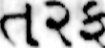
તરફ
